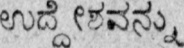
ಉದ್ದೇಶವನ್ನು
